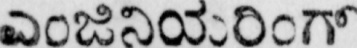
ಎಂಜಿನಿಯರಿಂಗ್
